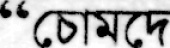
“চোমদে
